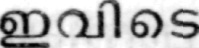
ഇവിടെ
